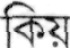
কিয়
